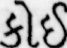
કોઈ
